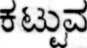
ಕಟ್ಟುವ
